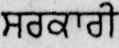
ਸਰਕਾਰੀ
